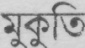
মুকুতি
